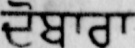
ਦੋਬਾਰਾ
